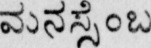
ಮನಸ್ಸೆಂಬ
